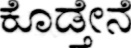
ಕೊಡ್ತೇನೆ
